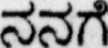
ನನಗೆ
